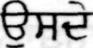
ਉਸਦੇ
